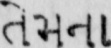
તેમના
